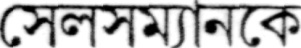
সেলসম্যানকে
